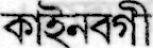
কাইনবগী
